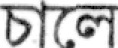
চালে
